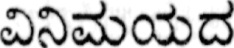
ವಿನಿಮಯದ
